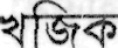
খজিক
